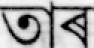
তাৰ
